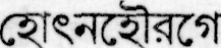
হোৎনহৌরগে
